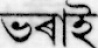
ভৰাই
